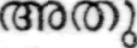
അതു
